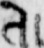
તો
